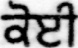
ਕੋਈ
